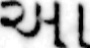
આ
